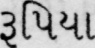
રૂપિયા
